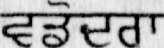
ਵਡੋਦਰਾ
